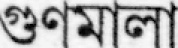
গুণমালা
